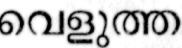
വെളുത്ത
